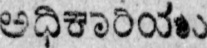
ಅಧಿಕಾರಿಯು
